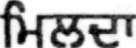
ਮਿਲਦਾ
